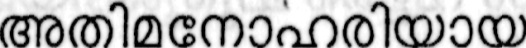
അതിമനോഹരിയായ
